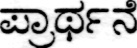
ಪ್ರಾರ್ಥನೆ
